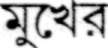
মুখের
